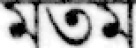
মতম
